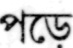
পড়ে
